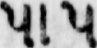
પાપ
